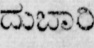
ದುಬಾರಿ
